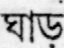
ঘাড়
